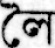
লৈ
